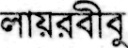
লায়রবীবু
